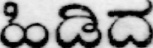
ಹಿಡಿದ
